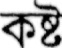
কষ্ট
